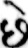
છે
